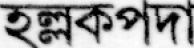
হল্লকপদা
